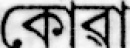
কোৱা
